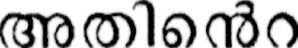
അതിന്റെ
